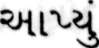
આપ્યું
